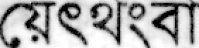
য়েৎথংবা
